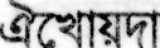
ঐখোয়দা
